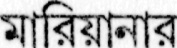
মারিয়ানার
